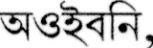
অওইবনি,
